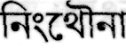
নিংথৌনা
